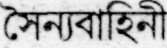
সৈন্যবাহিনী
